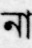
না
